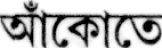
আঁকোতে
